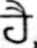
ਹੈ,
